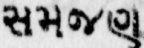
સમજણ
